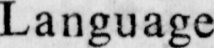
Language
